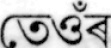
তেওঁৰ
